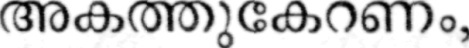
അകത്തുകേറണം,
